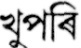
খুপৰি
